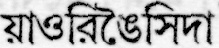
য়াওরিঙৈসিদা
